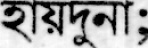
হায়দুনা;
